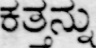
ಕತ್ತನ್ನು
